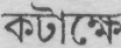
কটাক্ষে
